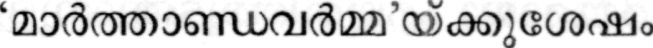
'മാര്‍ത്താണ്ഡവര്‍മ്മ'യ്ക്കുശേഷം
